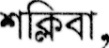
শক্লিবা,
